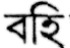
বহি
